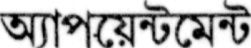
অ্যাপয়েন্টমেন্ট
